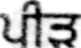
ਪੀੜ
